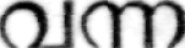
വന്ന
